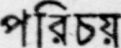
পরিচয়
